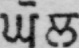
ਘੋਲ
